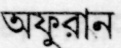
অফুরান
